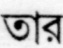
তার
